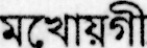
মখোয়গী
